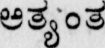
ಅತ್ಯಂತ
